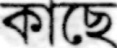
কাছে
